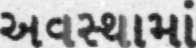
અવસ્થામાં
